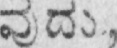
ವುದು,
